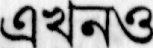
এখনও
